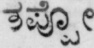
ತಪ್ಪೋ
